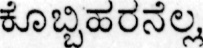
ಕೊಬ್ಬಿಹರನೆಲ್ಲ,
